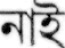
নাই
